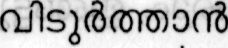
വിടുര്‍ത്താന്‍
